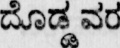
ದೊಡ್ಡವರ
